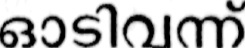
ഓടിവന്ന്
